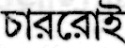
চাররোই
